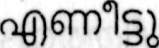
എണീട്ടു
